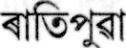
ৰাতিপুৱা
